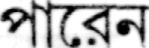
পারেন
